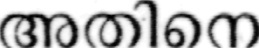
അതിനെ
